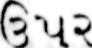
ઉપર
